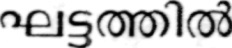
ഘട്ടത്തില്‍
